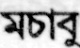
মচাবু
